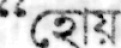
“হোয়
